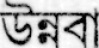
উন্নবা
